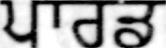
ਪਾਰਡ
